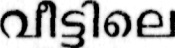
വീട്ടിലെ
